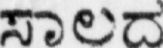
ಸಾಲದ
